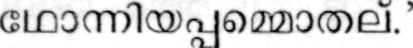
ഥോന്നിയപ്പമ്മൊതല്.'
